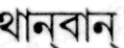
থান্‌বান্
